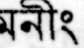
মনীং
